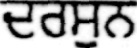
ਦਰਸਨੁ
